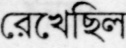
রেখেছিল
